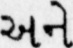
અને
